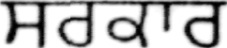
ਸਰਕਾਰ
